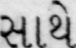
સાથે
